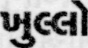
ખુલ્લો
